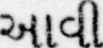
આવી
